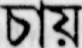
চায়
